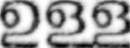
ഉള്ള
